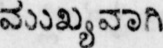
ಮುಖ್ಯವಾಗಿ
